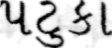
પટુકા
